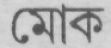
মোক
